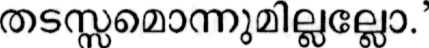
തടസ്സമൊന്നുമില്ലല്ലോ.'
